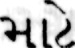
માટે
